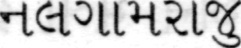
નલગામરાજુ
